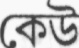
কেউ
